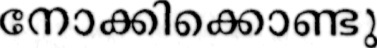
നോക്കിക്കൊണ്ടു
